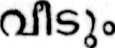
വീടും
